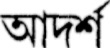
আদর্শ
